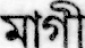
মাগী
